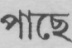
পাছে
